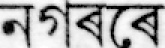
নগৰৰে
